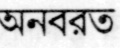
অনবরত
